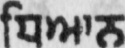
ਧਿਆਨ
